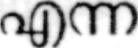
എന്ന
